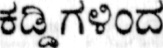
ಕಡ್ಡಿಗಳಿಂದ
